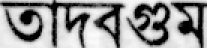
তাদবগুম
